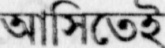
আসিতেই
